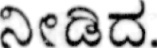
ನೀಡಿದ.
